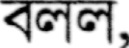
বলল,
